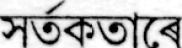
সর্তকতাৰে
